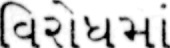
વિરોધમાં
